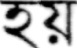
হয়
